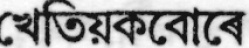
খেতিয়কবোৰে
